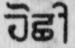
ਹੋਛੀ
